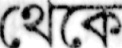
থেকে
